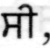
ਸੀ,
